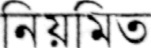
নিয়মিত
